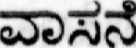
ವಾಸನೆ
